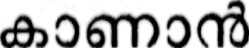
കാണാന്‍
